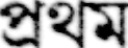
প্রথম
